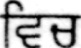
ਵਿਚ
